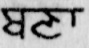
ਬਣਾ
